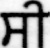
ਸੀ
